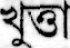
খুত্তা
